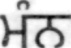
ਮੰਨ
